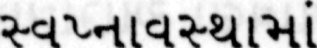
સ્વપ્નાવસ્થામાં
